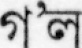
গ'ল
